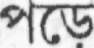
পড়ে
